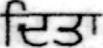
ਦਿਤਾ
